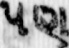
પણ
